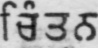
ਚਿੰਤਨ
